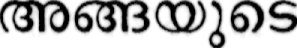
അങ്ങയുടെ
